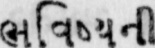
ભવિષ્યની
